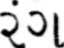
રંગ
